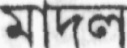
মাদল
